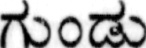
ಗುಂಡು
